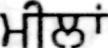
ਮੀਲਾਂ
